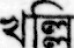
খল্লি
